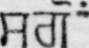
ਸਗੋਂ
